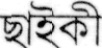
ছাইকী
